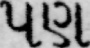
પણ
